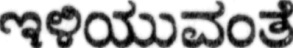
ಇಳಿಯುವಂತೆ
